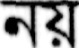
নয়
